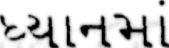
ધ્યાનમાં
